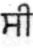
ਸੀ
